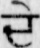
ਦੇ
